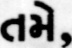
તમે,
